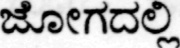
ಜೋಗದಲ್ಲಿ
